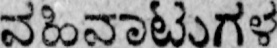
ವಹಿವಾಟುಗಳ
